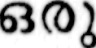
ഒരു
